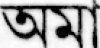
অমা
